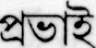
প্রভাই
